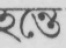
হন্তে
